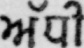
ਅੱਧੀ
